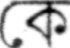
কে
